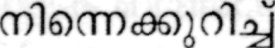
നിന്നെക്കുറിച്ച്
